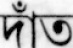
দাঁত
